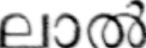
ലാല്‍
